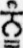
ਨੂੰ
